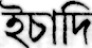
ইচাদি
